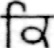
ਕਿ
